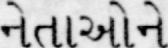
નેતાઓને
